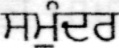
ਸਮੁੰਦਰ
